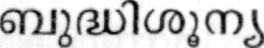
ബുദ്ധിശൂന്യ
